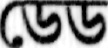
ডেড
